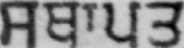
ਸਥਾਪਤ
